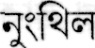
নুংথিল
